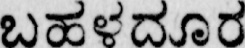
ಬಹಳದೂರ
